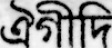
ঐগীদি
